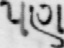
પણ
